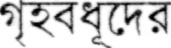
গৃহবধূদের
